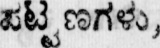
ಪಟ್ಟಣಗಳು,
